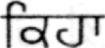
ਕਿਹਾ
